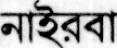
নাইরবা
